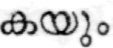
കയും
